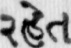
રહેત
